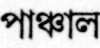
পাঞ্চাল
